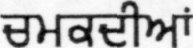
ਚਮਕਦੀਆਂ
